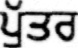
ਪੁੱਤਰ
